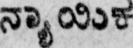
ನ್ಯಾಯಿಕ
